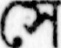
সে
